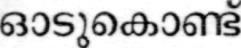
ഓടുകൊണ്ട്
